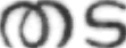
തട
